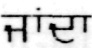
ਜਾਂਦਾ
